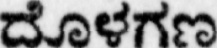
ದೊಳಗಣ
